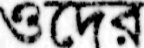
ওদের
